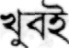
খুবই
